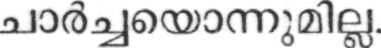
ചാര്‍ച്ചയൊന്നുമില്ല.
